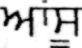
ਆਂਸੂ
